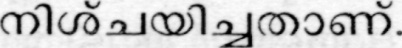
നിശ്ചയിച്ചതാണ്.
